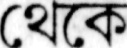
থেকে
